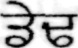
ਡੇਢ
